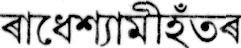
ৰাধেশ্যামীহঁতৰ
